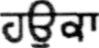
ਹਉਕਾ
